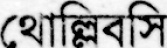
থোল্লিবসি
